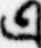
এ
